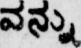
ವನ್ನು
